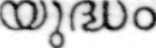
യുദ്ധം
